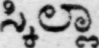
ಸ್ಕಿಲ್ಲಾ
